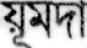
য়ূমদা
